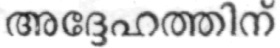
അദ്ദേഹത്തിന്
